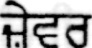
ਜ਼ੇਵਰ
